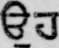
ਉਹ
